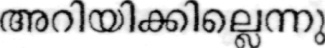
അറിയിക്കില്ലെന്നു
